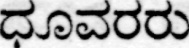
ಧೂವರರು
